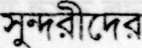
সুন্দরীদের
